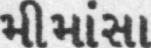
મીમાંસા
